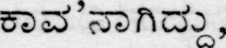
ಕಾವ’ನಾಗಿದ್ದು,
